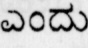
ಎಂದು
